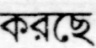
করছে
